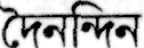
দৈনন্দিন
